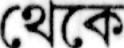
থেকে
